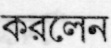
করলেন
